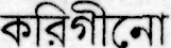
করিগীনো
